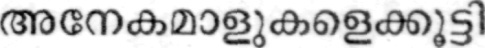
അനേകമാളുകളെക്കൂട്ടി
